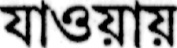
যাওয়ার
